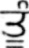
ਤੂੰ
